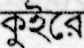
কুইরে
